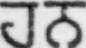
ਹਨ
